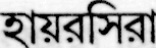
হায়রসিরা
